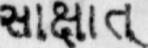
સાક્ષાત્
